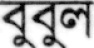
বুবুল
